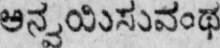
ಅನ್ವಯಿಸುವಂಥ
